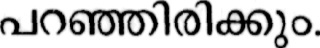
പറഞ്ഞിരിക്കും.
